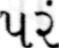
પરં
